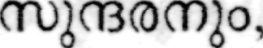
സുന്ദരനും,
